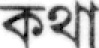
কথা
